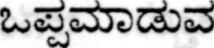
ಒಪ್ಪಮಾಡುವ
